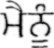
ਮੈਨੂੰ
